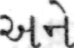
અને
